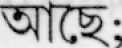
আছে;
